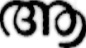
ആ
